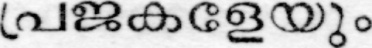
പ്രജകളേയും
